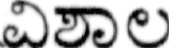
ವಿಶಾಲ
